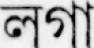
লগা
